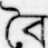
বৈ
